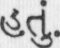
હતું.
